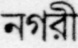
নগরী
